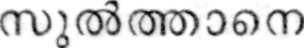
സുല്‍ത്താനെ
